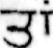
ਤਾਂ
